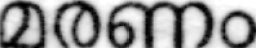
മരണം
